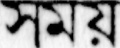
সময়
